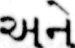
અને
